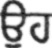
ਉਹ
